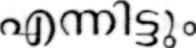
എന്നിട്ടും
